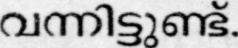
വന്നിട്ടുണ്ട്.
